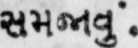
સમજાવું.
